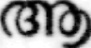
ആ
